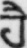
ਹੈ
